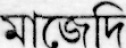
মাজেদি
